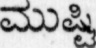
ಮುಷ್ಟಿ
